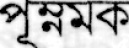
পূম্নমক
